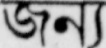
জন্য
